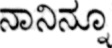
ನಾನಿನ್ನೂ
